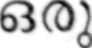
ഒരു
